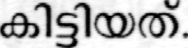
കിട്ടിയത്.
